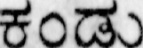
ಕಂಡು
